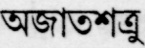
অজাতশত্রু
